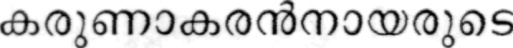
കരുണാകരന്‍നായരുടെ
